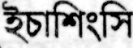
ইচাশিংসি
